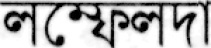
লম্ফেলদা
